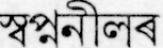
স্বপ্ননীলৰ
